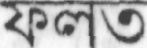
ফলত
